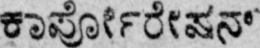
ಕಾರ್ಪೋರೇಷನ್
